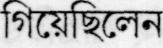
গিয়েছিলেন
